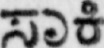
ಸಾಕಿ
